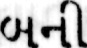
બની
